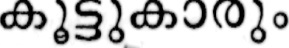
കൂട്ടുകാരും
